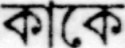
কাকে
